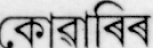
কোৱাৰিৰ
